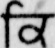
ਕਿ
